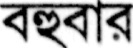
বহুবার
